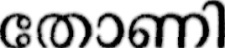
തോണി
